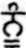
ਨੂੰ
